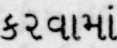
કરવામાં
